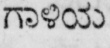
ಗಾಳಿಯ
